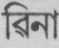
ৱিনা
